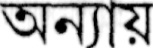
অন্যায়
